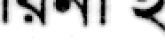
কায়না
